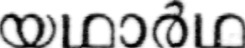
യഥാര്‍ഥ
